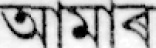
আমাৰ
